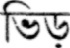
ভিড়
